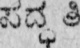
ಪದ್ಧತಿ
